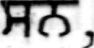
ਸਨ,
